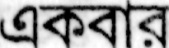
একবার
